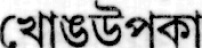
খোঙউপকা
